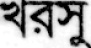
খরসু
